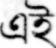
এই
